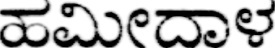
ಹಮೀದಾಳ
